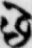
છે
